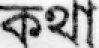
কথা
